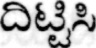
ದಿಟ್ಟಿಸಿ
